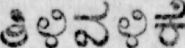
ತಿಳಿವಳಿಕೆ
